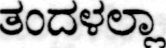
ತಂದಳಲ್ಲಾ
